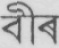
বীৰ
